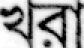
খরা
